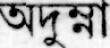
অদুম্না
